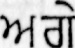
ਅਗੇ
